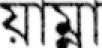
য়াম্না
